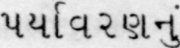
પર્યાવરણનું
